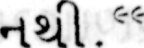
નથી.૯૯
